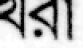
খরা
